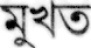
মুখত
